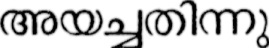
അയച്ചതിന്നു
